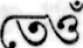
তেওঁ
